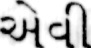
એવી
